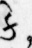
કે,
